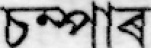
চম্পাৰ
